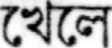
খেলে
